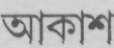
আকাশ
